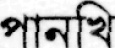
পানখি
